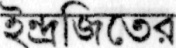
ইন্দ্রজিতের
